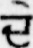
ਦੇ
